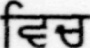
ਵਿਚ
